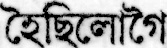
হৈছিলোগৈ
